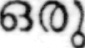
ഒരു
